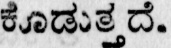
ಕೊಡುತ್ತದೆ.
